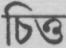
চিত্ত
